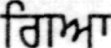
ਗਿਆ
